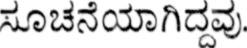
ಸೂಚನೆಯಾಗಿದ್ದವು.
